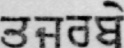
ਤਜਰਬੇ
